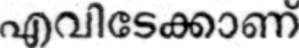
എവിടേക്കാണ്
